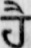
ਹੈ
